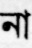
না
